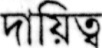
দায়িত্ব
